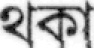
থকা
